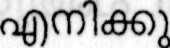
എനിക്കു
